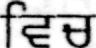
ਵਿਚ
